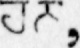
ਹਨ,
